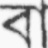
বা
